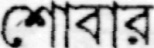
শোবার
